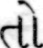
તો
